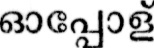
ഓപ്പോള്
